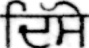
ਦਿੱਸੇ
